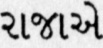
રાજાએ
